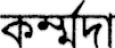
কর্ম্মদা
